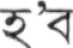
হ'ব
